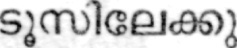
ടൂസിലേക്കു
